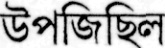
উপজিছিল
